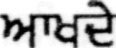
ਆਖਦੇ
